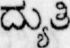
ದ್ಯುತಿ
